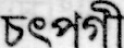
চৎপগী
